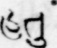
હતું
